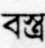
বস্ত্র
